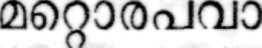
മറ്റൊരപവാ
